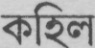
কহিল
